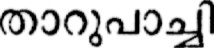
താറുപാച്ചി
